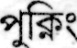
পুক্নিং
